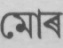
মোৰ
